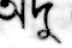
অদু
